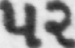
પર
